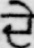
ਦੇ
